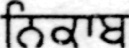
ਨਿਕਾਬ
